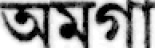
অমগা
